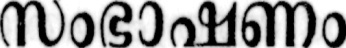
സംഭാഷണം
